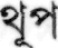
থূপ
